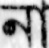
না
